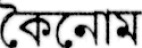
কৈনোম
